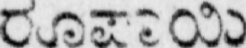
ರೂಪಾಯಿ
